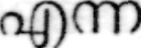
എന്ന
